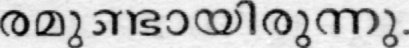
രമുണ്ടായിരുന്നു.
